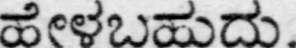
ಹೇಳಬಹುದು.
